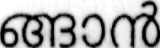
ങ്ങാന്‍
